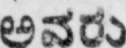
ಅವರು
